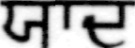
ਯਾਦ
